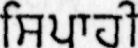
ਸਿਪਾਹੀ
